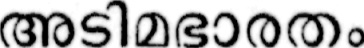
അടിമഭാരതം
